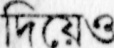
দিয়েও
